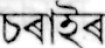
চৰাইৰ
